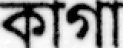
কাগা
